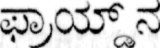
ಫ್ರಾಯ್ಡ್ನ
